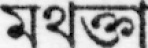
মথক্তা
